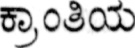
ಕ್ರಾಂತಿಯ
